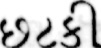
છટકી
